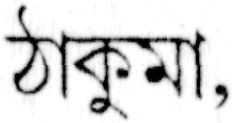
ঠাকুমা,
